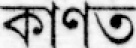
কাণত
